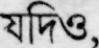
যদিও,
